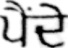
ਪੈਂਦੇ
